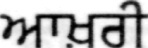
ਆਖ਼ਰੀ
